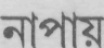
নাপায়
